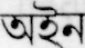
অইন
